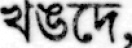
খঙদে,
